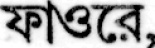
ফাওরে,
